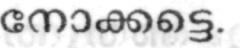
നോക്കട്ടെ.
